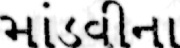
માંડવીના
